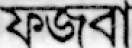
ফজবা
